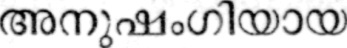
അനുഷംഗിയായ
